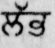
ਲੱਭ
